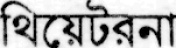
থিয়েটরনা
